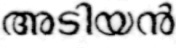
അടിയന്‍
